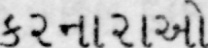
કરનારાઓ
